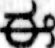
ಈ
